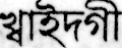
খ্বাইদগী
